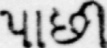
પાછી
